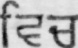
ਵਿਚ
